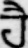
ਹੈ
